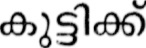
കുട്ടിക്ക്
